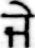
ਜੇ
